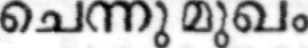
ചെന്നുമുഖം
